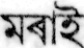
মৰাই
